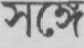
সঙ্গে
